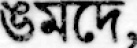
ঙমদে,
